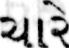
ચારે
